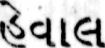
હેવાલ
